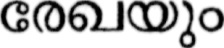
രേഖയും
